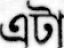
এটা
